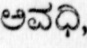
ಅವಧಿ,
